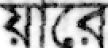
য়ারে
